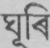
ঘূৰি
